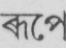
ৰূপে
